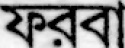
ফরবা
